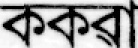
ককৱা
